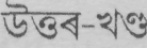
উত্তৰ-খণ্ড
